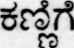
ಕಣ್ಣಿಗೆ
